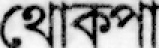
থোকপা
